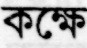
কক্ষে
